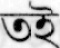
তই
